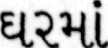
ઘરમાં
